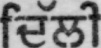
ਦਿੱਲੀ
